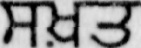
ਸਖ਼ਤ
